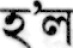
হ'ল
